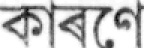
কাৰণে
